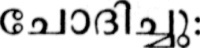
ചോദിച്ചു:
